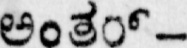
ಅಂತರ್-
